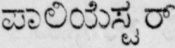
ಪಾಲಿಯೆಸ್ಟರ್
